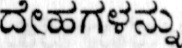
ದೇಹಗಳನ್ನು
